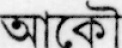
আকৌ
